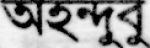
অহন্দুবু
